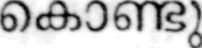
കൊണ്ടു
